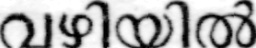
വഴിയില്‍
